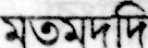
মতমদদি
